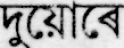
দুয়োৰে
